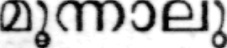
മൂന്നാലു
